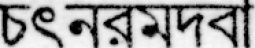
চৎনরমদবা
